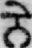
ਨੇ
